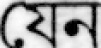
যেন
